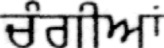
ਚੰਗੀਆਂ
